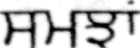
ਸਮਝਾਂ
